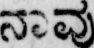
ನಾವು
